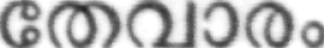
തേവാരം
